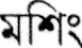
মশিং
